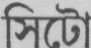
সিটো
